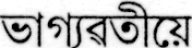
ভাগ্যৱতীয়ে
